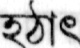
হঠাৎ
